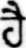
ਹੈ
